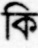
কি
